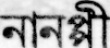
নানপ্পী
